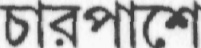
চারপাশে
